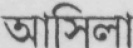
আসিলা
